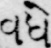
વધે
